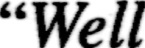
"Well
